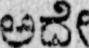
ಅದೇ
